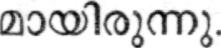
മായിരുന്നു.
